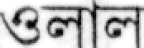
ওলাল
